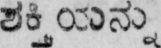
ಶಕ್ತಿಯನ್ನು
